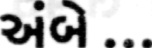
અંબે...
